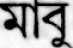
মাবু
